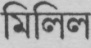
মিলিল
